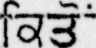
ਕਿਤੋਂ
